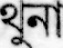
থুনা
